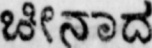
ಚೀನಾದ
